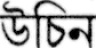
উচিন
